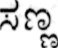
ಸಣ್ಣ
